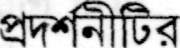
প্রদর্শনীটির
